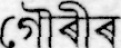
গৌৰীৰ
